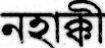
নহাক্কী
